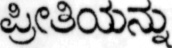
ಪ್ರೀತಿಯನ್ನು
